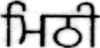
ਮਿਠੀ
